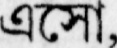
এসো,
